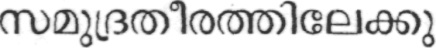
സമുദ്രതീരത്തിലേക്കു
